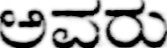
ಅವರು
